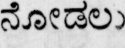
ನೋಡಲು
